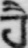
ਹੈ
